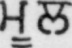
ਮੂਲ
